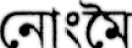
নোংমৈ
